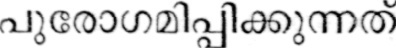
പുരോഗമിപ്പിക്കുന്നത്
